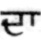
ਦਾ
